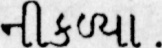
નીકળ્યા.
